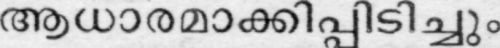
ആധാരമാക്കിപ്പിടിച്ചും
